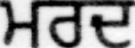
ਮਰਦ
